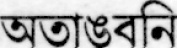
অতাঙবনি
